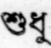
শুধু
